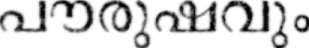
പൌരുഷവും
